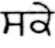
ਸਕੇ
